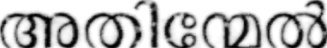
അതിന്മേല്‍
